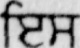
ਇਸ
